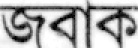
জবাক
